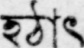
হঠাৎ
